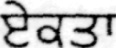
ਏਕਤਾ
